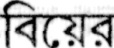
বিয়ের
